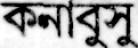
কনাবুসু
